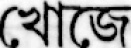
খোজে
